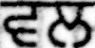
ਵਲ
